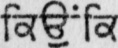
ਕਿਉਂਕਿ
